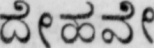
ದೇಹವೇ
